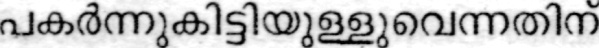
പകര്‍ന്നുകിട്ടിയുള്ളുവെന്നതിന്
